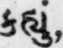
કહ્યું,
